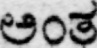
ಅಂತ
